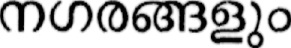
നഗരങ്ങളും
